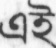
এই
